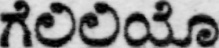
ಗೆಲಿಲಿಯೊ
